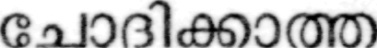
ചോദിക്കാത്ത
